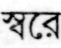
স্বরে
